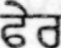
ਫੇਰ
